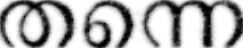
തന്നെ
